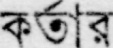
কর্তার
